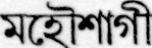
মহৌশাগী
